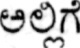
ಅಲ್ಲಿಗೆ
